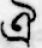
ঐ
